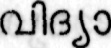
വിദ്യാ
